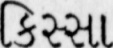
કિસ્સા
